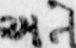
અને
